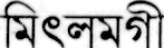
মিৎলমগী
